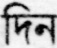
দিন
